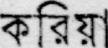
করিয়া
